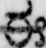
ಈ
